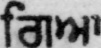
ਗਿਆ
